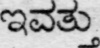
ಇವತ್ತು
